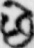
છે
